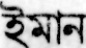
ইমান
